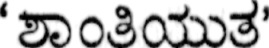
'ಶಾಂತಿಯುತ'
